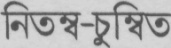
নিতম্ব-চুম্বিত
